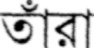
তাঁরা
